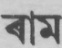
ৰাম
